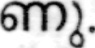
ണു.
